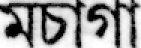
মচাগা
